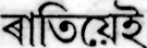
ৰাতিয়েই
